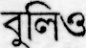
বুলিও
